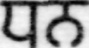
ਧਨ
